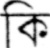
কি
